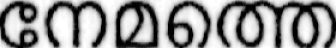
നേമത്തെ
